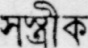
সস্ত্রীক
